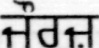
ਜੌਰਜ਼
